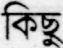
কিছু
